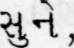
સુને,
